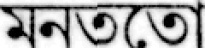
মনততো
